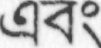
এবং
